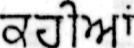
ਕਹੀਆਂ
